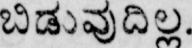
ಬಿಡುವುದಿಲ್ಲ.
